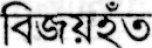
বিজয়হঁত
